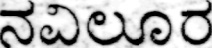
ನವಿಲೂರ
